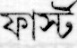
ফার্স্ট
